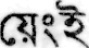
য়েংই
